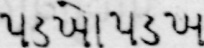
પડખોપડખ
